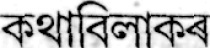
কথাবিলাকৰ
